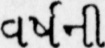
વર્ષની
